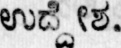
ಉದ್ದೇಶ.
